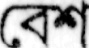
বেশ
